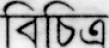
বিচিত্র
